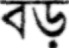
বড়
